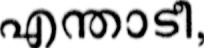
എന്താടീ,
